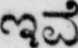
ಇವೆ
